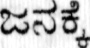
ಜನಕ್ಕೆ
